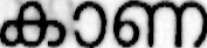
കാണ
